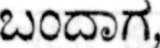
ಬಂದಾಗ,
